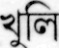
খুলি
